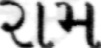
રામ
